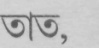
তাত,
